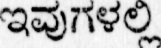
ಇವುಗಳಲ್ಲಿ
